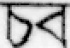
চব
